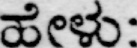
ಹೇಳು:
